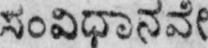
ಸಂವಿಧಾನವೇ
